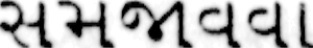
સમજાવવા
